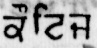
ਕੌਟਿਜ
